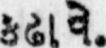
કઢાવે.
